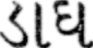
ડાઘ
